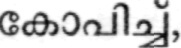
കോപിച്ച്,
